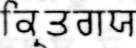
ਕ੍ਰਿਤਗਯ
